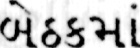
બેઠકમાં
